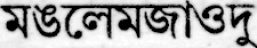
মঙলেমজাওদু
